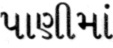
પાણીમાં
